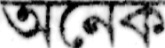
অনেক
